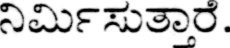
ನಿರ್ಮಿಸುತ್ತಾರೆ.
